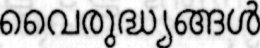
വൈരുദ്ധ്യങ്ങള്‍
